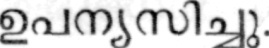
ഉപന്യസിച്ചു.
